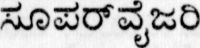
ಸೂಪರ್‌ವೈಜರಿ
